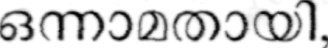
ഒന്നാമതായി,
